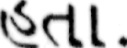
હતા.
